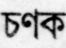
চণক
